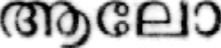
ആലോ
